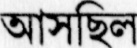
আসছিল
